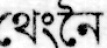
থেংনৈ
